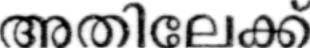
അതിലേക്ക്
